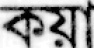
কয়া
